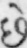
છે
